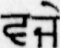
ਵਜੇ
